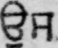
ਉਸ
